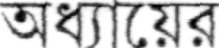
অধ্যায়ের
